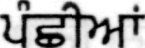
ਪੰਛੀਆਂ
